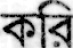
করি
